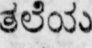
ತಲೆಯ
